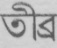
তীব্ৰ
